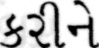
કરીને
